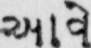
આવે
